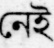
নেই
